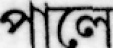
পালে
